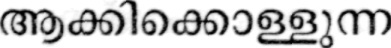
ആക്കിക്കൊള്ളുന്ന
